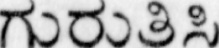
ಗುರುತಿಸಿ
